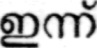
ഇന്ന്
